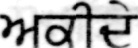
ਅਕੀਦੇ
